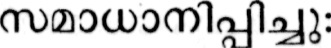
സമാധാനിപ്പിച്ചു:
